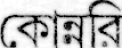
কোন্নরি
